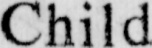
Child
